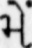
મેં
